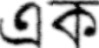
এক
